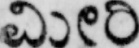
ಮೀರಿ
